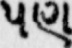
પણ
